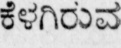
ಕೆಳಗಿರುವ
